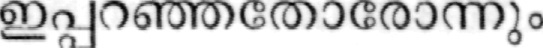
ഇപ്പറഞ്ഞതോരോന്നും
